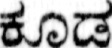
ಕೂಡ
